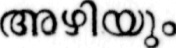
അഴിയും
